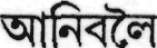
আনিবলৈ
